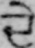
ਦੇ
